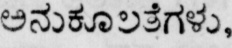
ಅನುಕೂಲತೆಗಳು,
